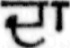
ਦਾ
